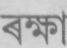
ৰক্ষা
